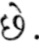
છે.
